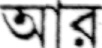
আর
